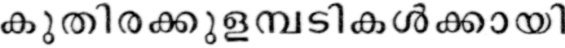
കുതിരക്കുളമ്പടികള്‍ക്കായി
